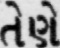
તેણે
